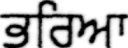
ਭਰਿਆ
